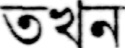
তখন
